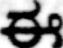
ಈ
